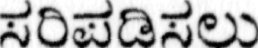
ಸರಿಪಡಿಸಲು
